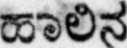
ಹಾಲಿನ
